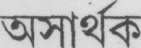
অসাৰ্থক
